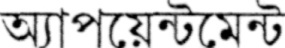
অ্যাপয়েন্টমেন্ট
